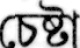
চেষ্টা
